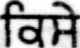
ਕਿਸੇ
